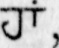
ਹਾਂ,
